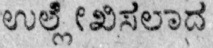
ಉಲ್ಲೇಖಿಸಲಾದ
